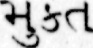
મુક્ત
